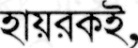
হায়রকই,
